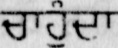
ਚਾਹੁੰਦਾ
